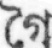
গৈ
